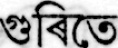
গুৰিতে
